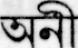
অনী
